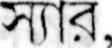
স্যার,
